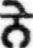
ਨੇ
